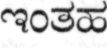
ಇಂತಹ
